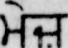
ਮੇਜ਼
